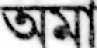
অমা
